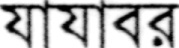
যাযাবর
